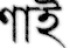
শাই
